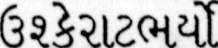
ઉશ્કેરાટભર્યો
